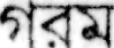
গরম
